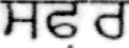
ਸਫ਼ਰ
